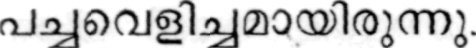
പച്ചവെളിച്ചമായിരുന്നു.
